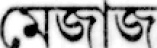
মেজাজ
